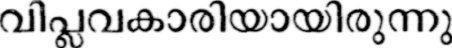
വിപ്ലവകാരിയായിരുന്നു
